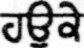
ਹਉਕੇ
